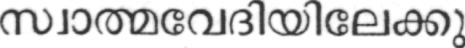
സ്വാത്മവേദിയിലേക്കു
